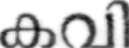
കവി
